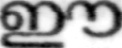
ഈ
